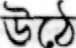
উঠে
